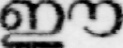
ഈ
